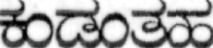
ಕಂಡಂತಹ
